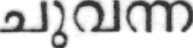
ചുവന്ന
